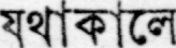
যথাকালে
